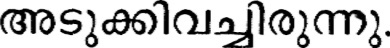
അടുക്കിവച്ചിരുന്നു.
